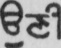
ਉਣੀ
